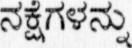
ನಕ್ಷೆಗಳನ್ನು
